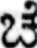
ಚೆ
